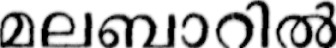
മലബാറില്‍
